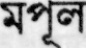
মপূল
